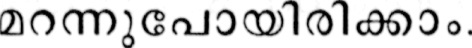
മറന്നുപോയിരിക്കാം.
